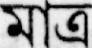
মাত্র
